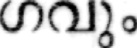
ഗവും
